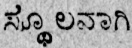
ಸ್ಥೂಲವಾಗಿ
